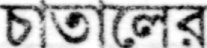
চাতালের
